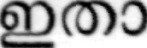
ഇതാ
